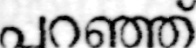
പറഞ്ഞ്
